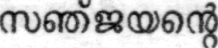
സഞ്ജയന്റെ
